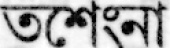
তশেংনা
